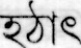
হঠাৎ
